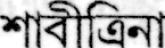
শাবীত্রিনা
